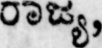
ರಾಜ್ಯ,
